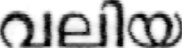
വലിയ
